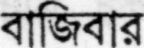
বাজিবার
